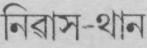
নিৱাস-থান
